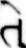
તે
